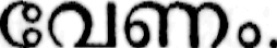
വേണം.
